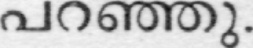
പറഞ്ഞു.
